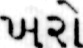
ખરો
